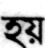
হয়
